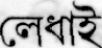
লেধাই
